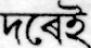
দৰেই
